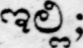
ಇಲ್ಲಿ;
